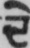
ਦੇ
